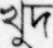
খুদ
